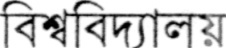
বিশ্ববিদ্যালয়
